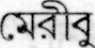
মেরীবু
